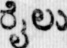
ರೈಲು
